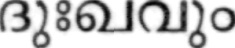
ദുഃഖവും
